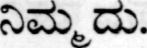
ನಿಮ್ಮದು.
